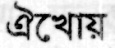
ঐখোয়
